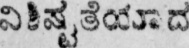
ವಿಶಿಷ್ಟತೆಯಾದ
